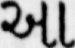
આ
